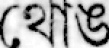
থোঙ
